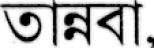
তান্নবা,
